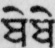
ਬੇਬੇ
